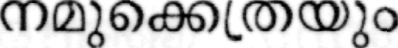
നമുക്കെത്രയും
